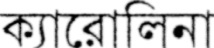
ক্যারোলিনা
